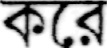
করে
